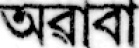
অৱাবা
